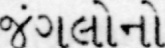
જંગલોનો
